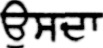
ਉਸਦਾ
